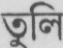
তুলি
